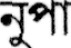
নুপা
